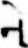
ને
